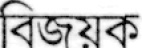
বিজয়ক
